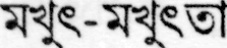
মখুৎ-মখুৎতা
